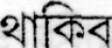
থাকিব
